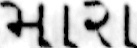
મારા
